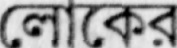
লোকের
